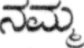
ನಮ್ಮ
